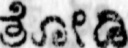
ತೋಡಿ
